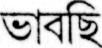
ভাবছি
